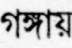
গঙ্গায়
